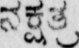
ನಕ್ಷತ್ರ
